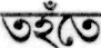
তহঁতে
